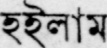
হইলাম
